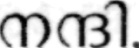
നന്ദി.
